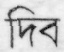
দিব
